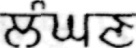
ਲੰਘਣ
